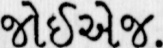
જોઈએજ.
